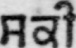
ਸਕੀ
